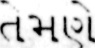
તેમણે
